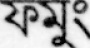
ফমুং
